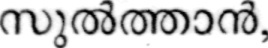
സുല്‍ത്താന്‍,
